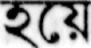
হয়ে
